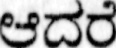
ಆದರೆ
